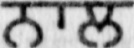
ਨਾਲ
